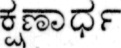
ಕ್ಷಣಾರ್ಧ
